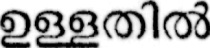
ഉള്ളതില്‍
